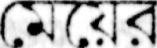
মেয়ের
